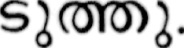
ടുത്തു.
